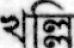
খল্লি
